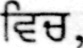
ਵਿਚ,
